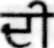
ਦੀ
